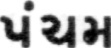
પંચમ
